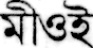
মীওই
